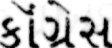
કૉંગ્રેસ
